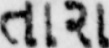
તારા
